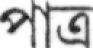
পাত্র
